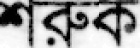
শরুক
